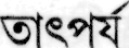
তাৎপর্য
